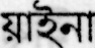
য়াইনা
